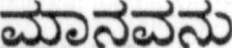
ಮಾನವನು
